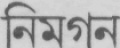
নিমগন
